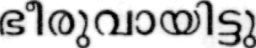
ഭീരുവായിട്ടു
